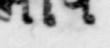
ભાવ
